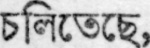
চলিতেছে,
